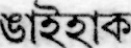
ঙাইহাক
